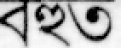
বহুত
